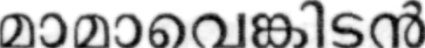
മാമാവെങ്കിടന്‍
